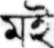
মই
